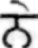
ਨੇ
